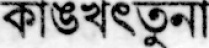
কাঙখৎতুনা
